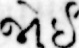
જોઈ
